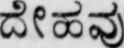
ದೇಹವು
